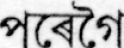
পৰেগৈ
